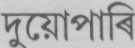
দুয়োপাৰি
